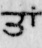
ਤਾਂ
